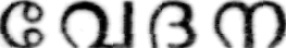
വേദന
